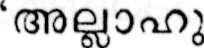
‘അല്ലാഹു
